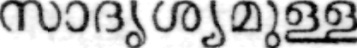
സാദൃശ്യമുള്ള
